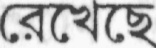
রেখেছে
